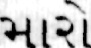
મારો
